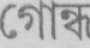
গোন্ধ
